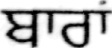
ਬਾਰਾਂ
